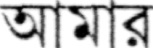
আমার
